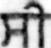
ਸੀ
